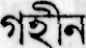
গহীন
